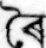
ৰৈ
